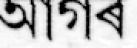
আগৰ
